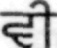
ਵੀ
